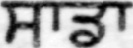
ਸਾਡਾ
